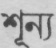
শূন্য
